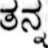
ತನ್ನ
